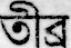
তীব্র
